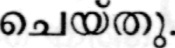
ചെയ്തു.
